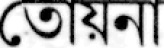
তোয়না
